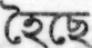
হৈছে
